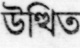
উত্থিত
